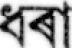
ধৰা
